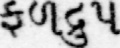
ફળદ્રુપ
